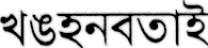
খঙহনবতাই
